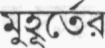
মুহূর্তের
